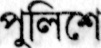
পুলিশে
